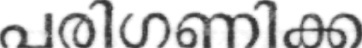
പരിഗണിക്ക
